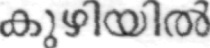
കുഴിയില്‍
